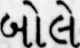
બોલે
